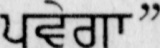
ਪਵੇਗਾ''
